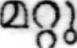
മറ്റു
